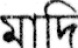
মাদি
